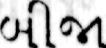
બીજા
